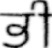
ਭੀ
